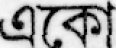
একো
